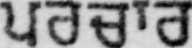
ਪਰਚਾਰ
